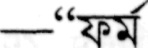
-"ফর্ম
